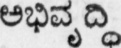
ಅಭಿವೃದ್ಧಿ
